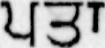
ਪਤਾ
